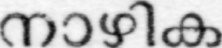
നാഴിക
